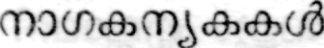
നാഗകന്യകകള്‍
